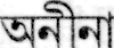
অনীনা
